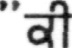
''ਕੀ
